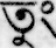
তুং
